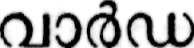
വാര്‍ഡ
